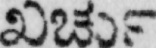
ಖರ್ಚು
